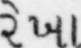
રેખા
